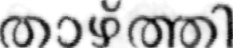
താഴ്ത്തി
